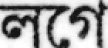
লগে
